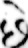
છે
